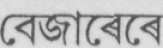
বেজাৰেৰে
